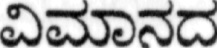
ವಿಮಾನದ
